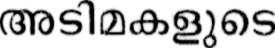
അടിമകളുടെ
